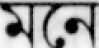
মনে
